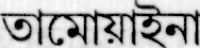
তামোয়াইনা
